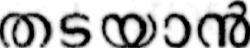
തടയാന്‍
